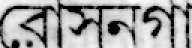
রোসনগা
